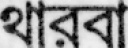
থারবা
